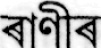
ৰাণীৰ
